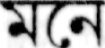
মনে
